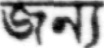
জন্য
